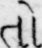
તો
